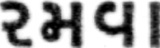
રમવા
